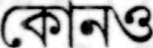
কোনও
